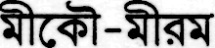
মীকৌ-মীরম
